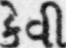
કેવી
